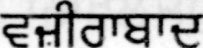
ਵਜ਼ੀਰਾਬਾਦ
